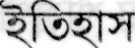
ইতিহাস
